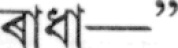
ৰাধা-"
